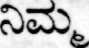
ನಿಮ್ಮ
